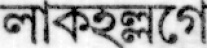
লাকহল্লগে
